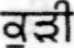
ਕੁੜੀ
